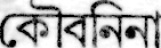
কৌবনিনা
